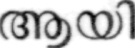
ആയി
